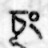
চূং
